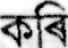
কৰি
